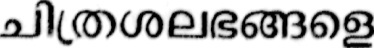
ചിത്രശലഭങ്ങളെ
